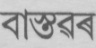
বাস্তৱৰ
